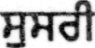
ਸੁਸਰੀ
